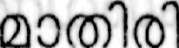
മാതിരി
